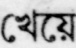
খেয়ে
